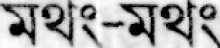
মথং-মথং
